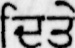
ਦਿਤੇ
